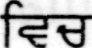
ਵਿਚ
